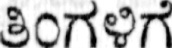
ತಿಂಗಳಿಗೆ
